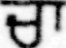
ਚਾ
